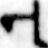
ન
